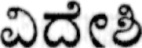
ವಿದೇಶಿ
